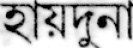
হায়দুনা
